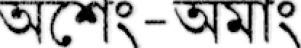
অশেং-অমাং
